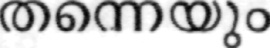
തന്നെയും
